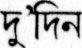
দুদিন
